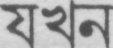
যখন
